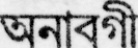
অনাবগী
